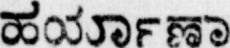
ಹರ್ಯಾಣ
